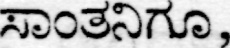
ಸಾಂತನಿಗೂ,
